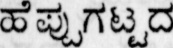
ಹೆಪ್ಪುಗಟ್ಟದ
